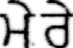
ਮੇਰੇ
